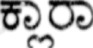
ಕ್ಲಾರಾ
